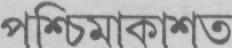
পশ্চিমাকাশত
